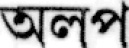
অলপ
